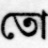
তো
